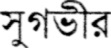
সুগভীর
